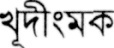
খূদীংমক
